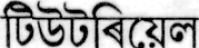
টিউটৰিয়েল
